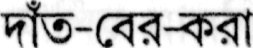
দাঁত-বের-করা
